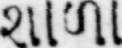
શાળા
